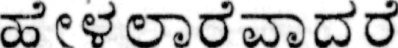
ಹೇಳಲಾರೆವಾದರೆ
